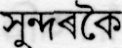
সুন্দৰকৈ
